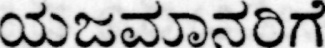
ಯಜಮಾನರಿಗೆ
